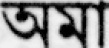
অমা
